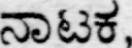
ನಾಟಕ,
